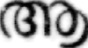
ആ
